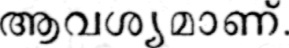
ആവശ്യമാണ്.
